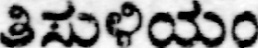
ತಿಸುಳಿಯಂ
